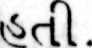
હતી.
